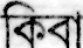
কিবা
